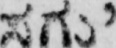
ಸಗು’
